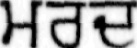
ਮਰਦ
